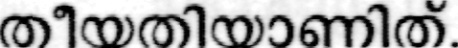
തീയതിയാണിത്.
